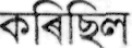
কৰিছিল
